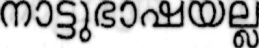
നാട്ടുഭാഷയല്ല
